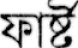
ফার্ষ্ট
